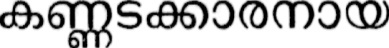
കണ്ണടക്കാരനായ
